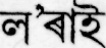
ল'ৰাই
